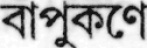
বাপুকণে
